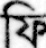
ফি
